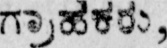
ಗ್ರಾಹಕರು,
